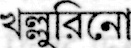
খল্লুরিনো
